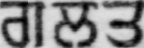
ਗਲਤ
